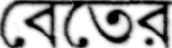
বেতের
